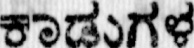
ಕಾಡುಗಳ
